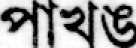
পাখঙ
